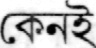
কেনই
